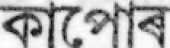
কাপোৰ
